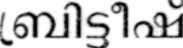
ബ്രിട്ടീഷ്
